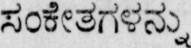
ಸಂಕೇತಗಳನ್ನು
